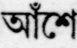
আঁশে
